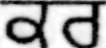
ਕਰ
